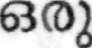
ഒരു
